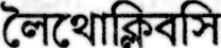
লৈথোক্লিবসি
